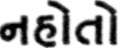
નહોતો
